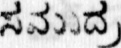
ಸಮುದ್ರ
